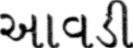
આવડી
